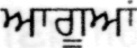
ਆਗੂਆਂ
